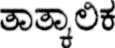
ತಾತ್ಕಾಲಿಕ
